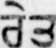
ਰੇਤ
